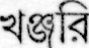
খঞ্জরি
